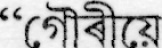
"গৌৰীয়ে
